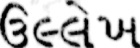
ઉલ્લેખ
